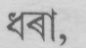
ধৰা,
